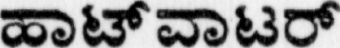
ಹಾಟ್‌ವಾಟರ್
